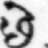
છે.
